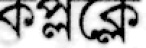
কপ্লক্লে
